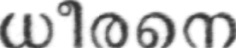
ധീരനെ
